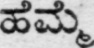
ಹೆಮ್ಮೆ
